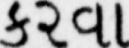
કરવા
